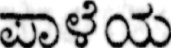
ಪಾಳೆಯ
